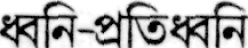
ধ্বনি-প্রতিধ্বনি
